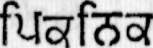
ਪਿਕਨਿਕ
